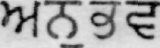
ਅਨੁਭਵ
